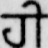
ਹੀ
